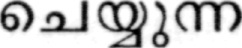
ചെയ്യുന്ന
